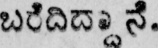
ಬರೆದಿದ್ದಾನೆ.
